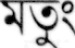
মতুং
